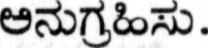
ಅನುಗ್ರಹಿಸು.
